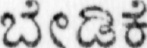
ಬೇಡಿಕೆ
